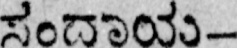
ಸಂದಾಯ-
